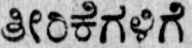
ತೀರಿಕೆಗಳಿಗೆ
